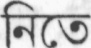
নিতে
